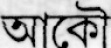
আকৌ
